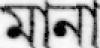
মানা
